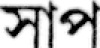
সাপ
